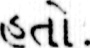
હતો.
